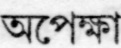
অপেক্ষা
